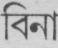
বিনা
